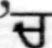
'ਚ
